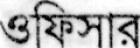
ওফিসার
